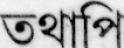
তথাপি
